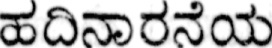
ಹದಿನಾರನೆಯ
